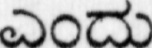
ಎಂದು
